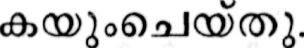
കയുംചെയ്തു.
